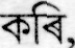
কৰি,
